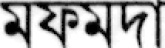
মফমদা
